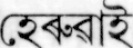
হেৰুৱাই
